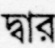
দ্বার
